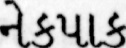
નેકપાક
